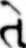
તે
